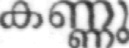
കണ്ണു
